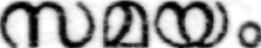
സമയം
